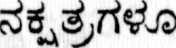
ನಕ್ಷತ್ರಗಳೂ
